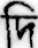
দি
